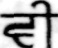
ਵੀ
